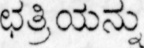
ಛತ್ರಿಯನ್ನು
